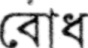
বোধ
